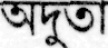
অদুতা
